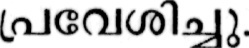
പ്രവേശിച്ചു.
